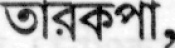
তারকপা,
